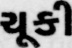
ચૂકી
